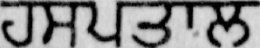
ਹਸਪਤਾਲ
